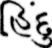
હિંદુ
